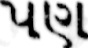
પણ
